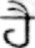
ਹੈ
